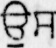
ਉਸ
